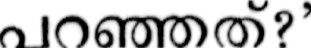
പറഞ്ഞത്?’
